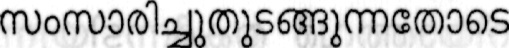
സംസാരിച്ചുതുടങ്ങുന്നതോടെ
